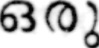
ഒരു
